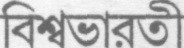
বিশ্বভারতী
